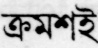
ক্রমশই
